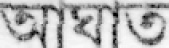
আঘাত
